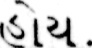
હોય.
